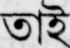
তাই
